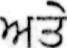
ਅਤੇ
